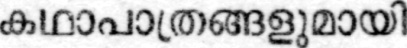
കഥാപാത്രങ്ങളുമായി
